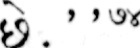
છે.૭૪
